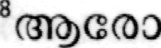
8ആരോ
